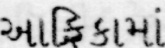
આફ્રિકામાં
